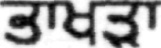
ਭਾਖੜਾ
